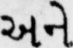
અને
